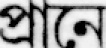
প্রানে
